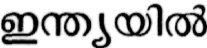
ഇന്ത്യയില്‍
